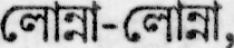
লোন্না-লোন্না,
